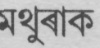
মথুৰাক
